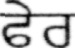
ਫੇਰ
